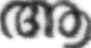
ആ
